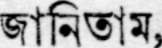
জানিতাম,
